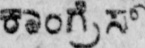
ಕಾಂಗ್ರೆಸ್
